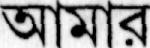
আমার
